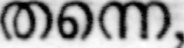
തന്നെ,
